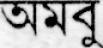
অমবু
